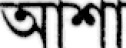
আশা
